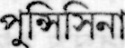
পুন্সিসিনা
